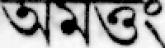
অমত্তং
